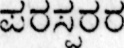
ಪರಸ್ಪರರ
